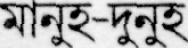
মানুহ-দুনুহ
